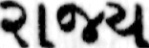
રાજ્ય
